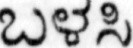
ಬಳಸಿ
